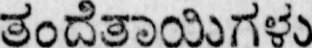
ತಂದೆತಾಯಿಗಳು
